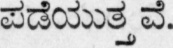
ಪಡೆಯುತ್ತವೆ.
